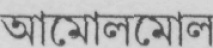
আমোলমোল
